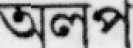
অলপ
